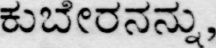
ಕುಬೇರನನ್ನು,
